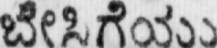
ಬೇಸಿಗೆಯು
